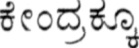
ಕೇಂದ್ರಕ್ಕೂ
